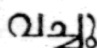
വച്ചു
